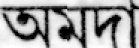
অমদা
